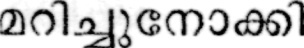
മറിച്ചുനോക്കി
